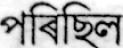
পৰিছিল
